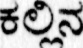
ಕಲ್ಲಿನ
